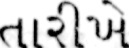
તારીખે
